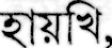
হায়খি,
